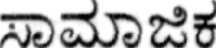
ಸಾಮಾಜಿಕ
